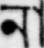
না
